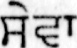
ਸੇਵਾ
